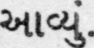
આવ્યું.
